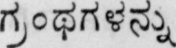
ಗ್ರಂಥಗಳನ್ನು
